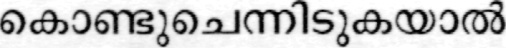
കൊണ്ടുചെന്നിടുകയാല്‍
